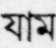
যাম
